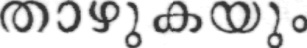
താഴുകയും
